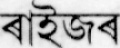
ৰাইজৰ
